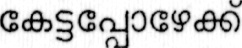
കേട്ടപ്പോഴേക്ക്
